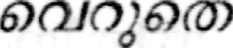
വെറുതെ
